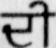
ਦੀ
